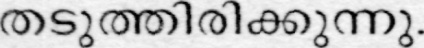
തടുത്തിരിക്കുന്നു.
